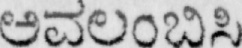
ಅವಲಂಬಿಸಿ
